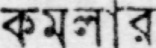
কমলার
